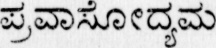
ಪ್ರವಾಸೋದ್ಯಮ
